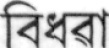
বিধৱা
